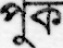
পুক
